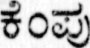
ಕೆಂಪು
